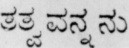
ತತ್ವವನ್ನನು
